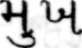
મુખ
